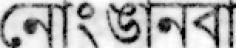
নোংঙানবা
